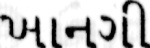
ખાનગી
